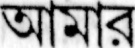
আমার
